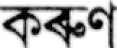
কৰুণ
